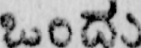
ಒಂದು
